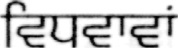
ਵਿਧਵਾਵਾਂ
